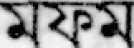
মফম
